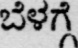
ಬೆಳಗ್ಗೆ
